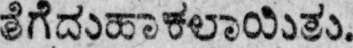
ತೆಗೆದುಹಾಕಲಾಯಿತು.
